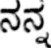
ನನ್ನ
